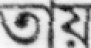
তায়
